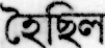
হৈছিল
